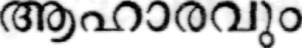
ആഹാരവും
